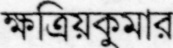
ক্ষত্রিয়কুমার
